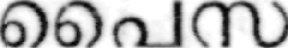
പൈസ
